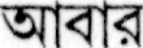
আবার
